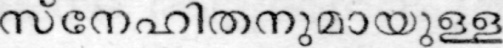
സ്നേഹിതനുമായുള്ള
